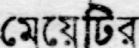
মেয়েটির
